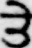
ਤੇ
